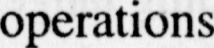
operations
